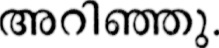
അറിഞ്ഞു.
